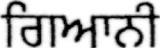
ਗਿਆਨੀ
